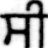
ਸੀ
